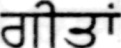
ਗੀਤਾਂ
